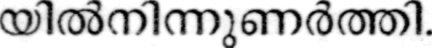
യില്‍നിന്നുണര്‍ത്തി.
